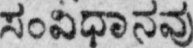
ಸಂವಿಧಾನವು
